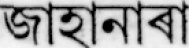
জাহানাৰা
